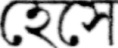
হেসে
